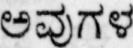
ಅವುಗಳ
